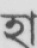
হা
